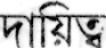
দায়িত্ব
